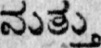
ಮತ್ತು
